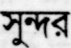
সুন্দর
